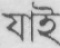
যাই
